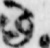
છે.
